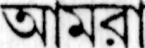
আমরা
